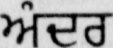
ਅੰਦਰ
